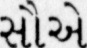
સૌએ
